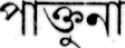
পাক্তুনা
